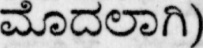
ಮೊದಲಾಗಿ)
